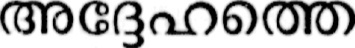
അദ്ദേഹത്തെ
